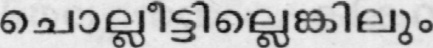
ചൊല്ലീട്ടില്ലെങ്കിലും
